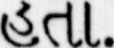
હતા.
